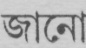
জানো
